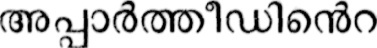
അപ്പാര്‍ത്തീഡിന്റെ
